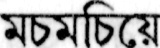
মচমচিয়ে
